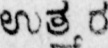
ಉತ್ತರ
